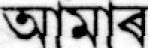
আমাৰ
